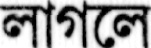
লাগলে
